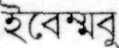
ইবেম্মবু
